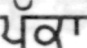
ਪੱਕਾ
